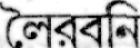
লৈরবনি
